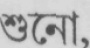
শুনো,
